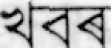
খবৰ
